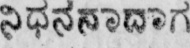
ನಿಧನನಾದಾಗ
